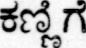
ಕಣ್ಣಿಗೆ
